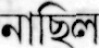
নাছিল
